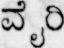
ವೈರಿ
